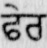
ਫੇਰ
